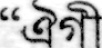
“ঐগী
